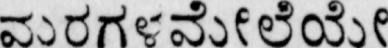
ಮರಗಳಮೇಲೆಯೇ
